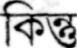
কিন্তু
